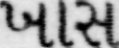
ખાસ
